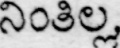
ನಿಂತಿಲ್ಲ,
